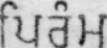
ਪਿਰੰਮ
